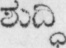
ಶುದ್ಧಿ
